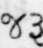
જરૂ
